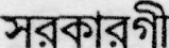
সরকারগী
